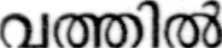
വത്തില്‍
